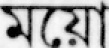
ময়ো
